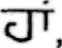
ਹਾਂ,
